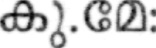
കു.മേ:
